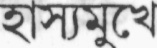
হাস্যমুখে
